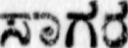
ಸಾಗರ
